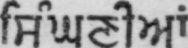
ਸਿੰਘਣੀਆਂ
